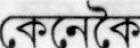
কেনেকৈ
